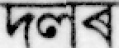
দলৰ
